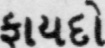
ફાયદો
